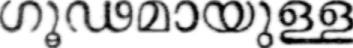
ഗൂഢമായുള്ള
